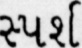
સ્પર્શ
